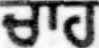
ਚਾਹ
